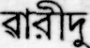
ৱারীদু
